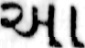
આ
